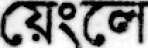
য়েংলে
